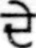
ਦੇ
